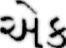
એક
